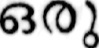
ഒരു
